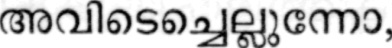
അവിടെച്ചെല്ലുന്നോ,
